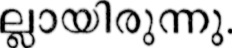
ല്ലായിരുന്നു.
